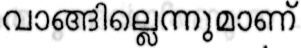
വാങ്ങില്ലെന്നുമാണ്
